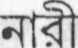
নারী
